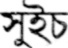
সুইচ
